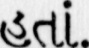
હતાં.
